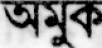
অমুক
